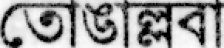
তোঙাল্লবা
